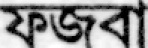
ফজবা
